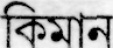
কিমান
